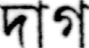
দাগ
